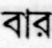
বার
